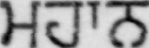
ਮਹਾਨ
